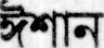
ঈশান
